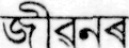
জীৱনৰ
